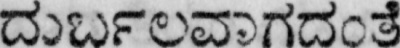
ದುರ್ಬಲವಾಗದಂತೆ
